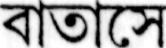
বাতাসে
